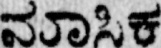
ಮಾಸಿಕ
